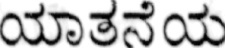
ಯಾತನೆಯ
